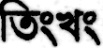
তিংখং
